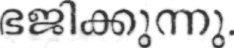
ഭജിക്കുന്നു.
